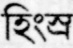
হিংস্র
